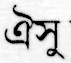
ঐসু
